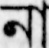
না
